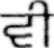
ਵੀ
